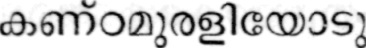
കണ്ഠമുരളിയോടു
